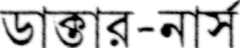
ডাক্তার-নার্স
